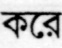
করে
